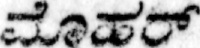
ಮೊಹರ್
